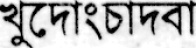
খুদোংচাদবা
